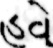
હવે
